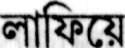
লাফিয়ে
